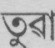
তুৱা
